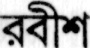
রবীশ
